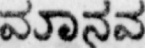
ಮಾನವ
